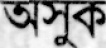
অসুক
